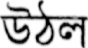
উঠল
